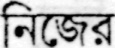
নিজের
